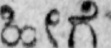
ಹೀಗೆ
